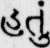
હતું
